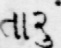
તારું
